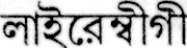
লাইরেম্বীগী
